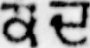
ਕਦ
